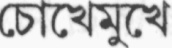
চোখেমুখে
